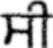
ਸੀ
